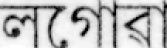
লগোৱা
